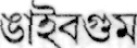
ঙাইবগুম
